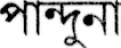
পান্দুনা
